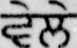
ਵੇਲੇ
